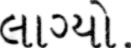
લાગ્યો.
